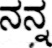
ನನ್ನ
